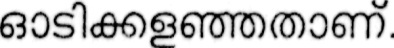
ഓടിക്കളഞ്ഞതാണ്.
